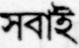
সবাই
